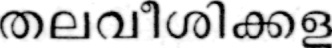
തലവീശിക്കള
